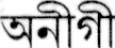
অনীগী
